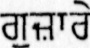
ਗੁਜ਼ਾਰੇ
